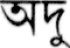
অদু
